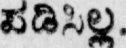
ಪಡಿಸಿಲ್ಲ.
